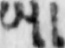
બા
